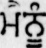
ਮੈਨੂੰ
